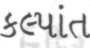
કલ્પાંત
